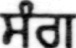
ਸੰਗ
